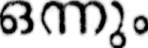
ഒന്നും
